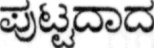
ಪುಟ್ಟದಾದ
